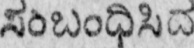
ಸಂಬಂಧಿಸಿದ
